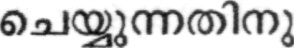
ചെയ്യുന്നതിനു
